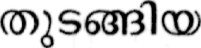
തുടങ്ങിയ
